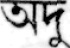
অদু
